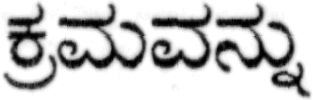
ಕ್ರಮವನ್ನು
